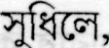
সুধিলে,
